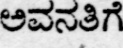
ಅವನತಿಗೆ
